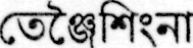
তেঞ্জৈশিংনা
